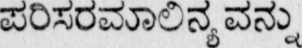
ಪರಿಸರಮಾಲಿನ್ಯವನ್ನು
